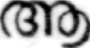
ആ
